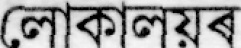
লোকালয়ৰ
